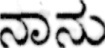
ನಾನು
